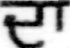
ਦਾ
